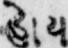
હોય
